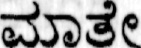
ಮಾತೇ
